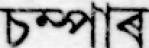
চম্পাৰ
